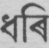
ধৰি
